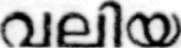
വലിയ
